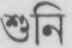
শুনি
